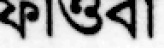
ফাওবা
